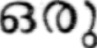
ഒരു
